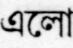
এলো
